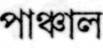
পাঞ্চাল
